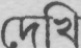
দেখি
